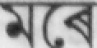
মৰে
